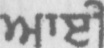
ਆਈ
